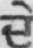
ਦੇ
